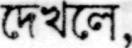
দেখলে,
